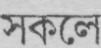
সকলে
